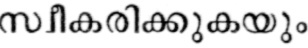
സ്വീകരിക്കുകയും
